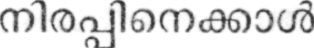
നിരപ്പിനെക്കാള്‍
